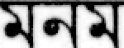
মনম
